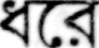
ধরে
